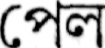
পেল
